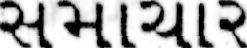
સમાચાર
